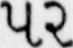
પર
